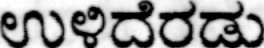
ಉಳಿದೆರಡು
